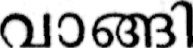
വാങ്ങി
